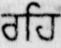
ਰਹਿ
